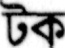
টক
